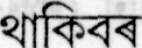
থাকিবৰ
